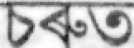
চৰুত
